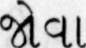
જોવા
